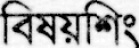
বিষয়শিং
